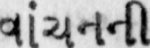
વાંચનની
